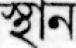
স্থান
